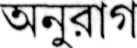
অনুরাগ
